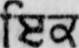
ਇਕ
